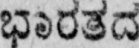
ಭಾರತದ
